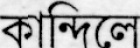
কান্দিলে
